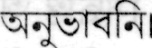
অনুভাবনি।
